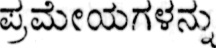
ಪ್ರಮೇಯಗಳನ್ನು
